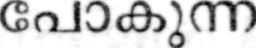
പോകുന്ന
